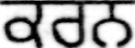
ਕਰਨ
